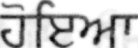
ਹੋਇਆ
